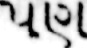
પણ
